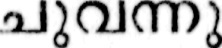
ചുവന്നു
